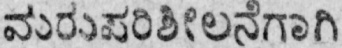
ಮರುಪರಿಶೀಲನೆಗಾಗಿ
